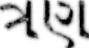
ત્રણ
